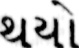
થયો
